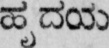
ಹೃದಯ
